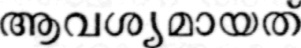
ആവശ്യമായത്
